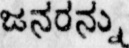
ಜನರನ್ನು
